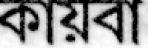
কায়বা
